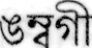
ঙম্বগী
